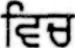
ਵਿਚ
